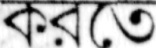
করতে
